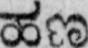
ಹಣ
